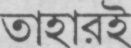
তাহারই
